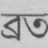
ব্ৰত
